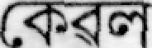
কেৱল
